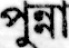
পু্ন্না
